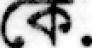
কে.
